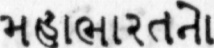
મહાભારતનો
